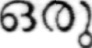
ഒരു
